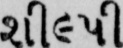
શીલ્પી
